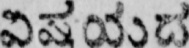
ವಿಷಯದ
